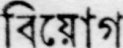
বিয়োগ
